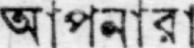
আপনারা
